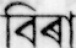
বিৰা
